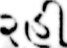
રહી
